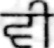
ਵੀ
